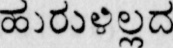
ಹುರುಳಿಲ್ಲದ
